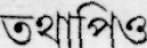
তথাপিও
